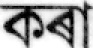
কৰা
